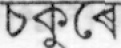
চকুৰে
